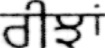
ਰੀਝਾਂ
